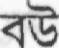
বউ
